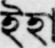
ইহা
